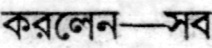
করলেন–সব
